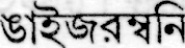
ঙাইজরম্বনি
